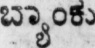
ಬ್ಯಾಂಕು
